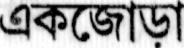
একজোড়া
